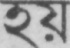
হয়
